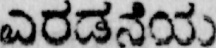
ಎರಡನೆಯ
